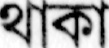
থাকা
